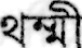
থম্মী
